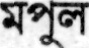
মপুল
